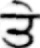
ਤੇ
